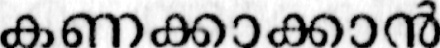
കണക്കാക്കാന്‍
